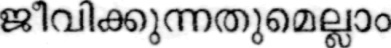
ജീവിക്കുന്നതുമെല്ലാം
